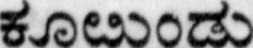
ಕೂೞುಂಡು
